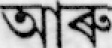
আৰু
